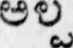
ಅಲ್ಪ
